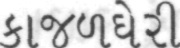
કાજળઘેરી
